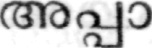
അപ്പാ
